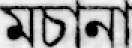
মচানা
